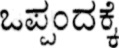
ಒಪ್ಪಂದಕ್ಕೆ
